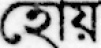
হোয়
